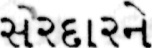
સરદારને
